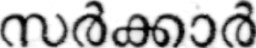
സര്‍ക്കാര്‍
